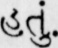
હતું.
